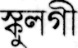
স্কুলগী
